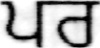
ਪਰ
